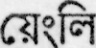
য়েংলি
